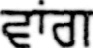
ਵਾਂਗ
